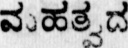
ಮಹತ್ವದ
